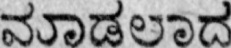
ಮಾಡಲಾದ
